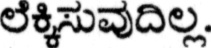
ಲೆಕ್ಕಿಸುವುದಿಲ್ಲ.
